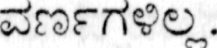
ವರ್ಣಗಳಿಲ್ಲ.
